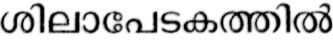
ശിലാപേടകത്തില്‍
